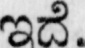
ಇದೆ.
